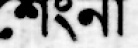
শেংনা
